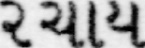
રચાય
